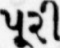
પૂરી
